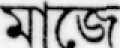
মাজে
